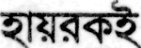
হায়রকই
